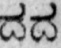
ದದ
